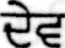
ਦੇਵ
